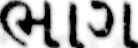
ભાગ
